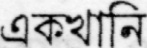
একখানি
